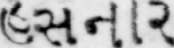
હસનાર
